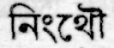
নিংথৌ
